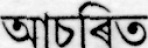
আচৰিত
